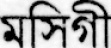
মসিগী
